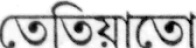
তেতিয়াতো
